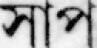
সাপ
